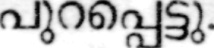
പുറപ്പെട്ടു.
